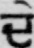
ਦੇ
